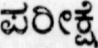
ಪರೀಕ್ಷೆ
